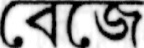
বেজে
